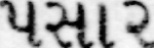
પસાર
